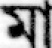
মা
